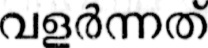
വളര്‍ന്നത്
